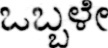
ಒಬ್ಬಳೇ
